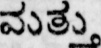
ಮತ್ತು
